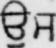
ਉਸ
